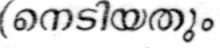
(നെടിയതും
